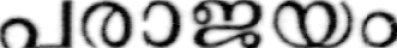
പരാജയം
